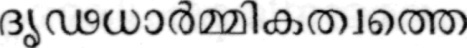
ദൃഢധാര്‍മ്മികത്വത്തെ
